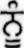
ਨੂੰ
